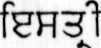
ਇਸਤ੍ਰੀ
